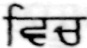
ਵਿਚ
